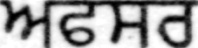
ਅਫਸਰ
